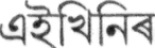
এইখিনিৰ
